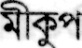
মীকুপ
